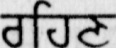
ਰਹਿਣ
